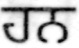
ਹਨ
